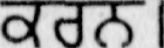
ਕਰਨ।
